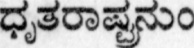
ಧೃತರಾಷ್ಟ್ರನುಂ
